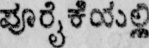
ಪೂರೈಕೆಯಲ್ಲಿ
